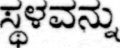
ಸ್ಥಳವನ್ನು
